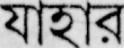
যাহার
